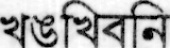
খঙখিবনি
